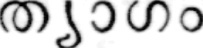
ത്യാഗം
